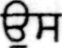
ਉਸ
